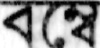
বম্বে
